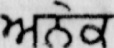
ਅਨੇਕ
